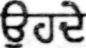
ਉਹਦੇ
